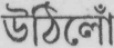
উঠিলোঁ
